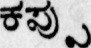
ಕಪ್ಪು
